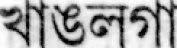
খাঙলগা
